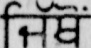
ਜਿੱਥੋਂ
